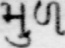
મુળ
